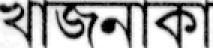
খাজনাকা
